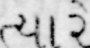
ત્યારે
